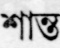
শান্ত
